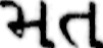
મત
